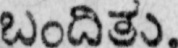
ಬಂದಿತು.
